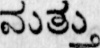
ಮತ್ತು
